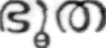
ഭൂത
